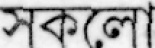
সকলো
